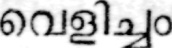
വെളിച്ചം
